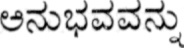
ಅನುಭವವನ್ನು
